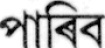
পাৰিব
